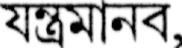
যন্ত্রমানব,
